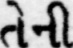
તેની
